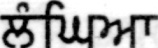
ਲੰਘਿਆ
